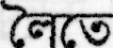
লৈতে
